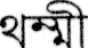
থম্মী
